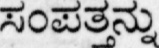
ಸಂಪತ್ತನ್ನು
